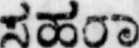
ಸಹರಾ
